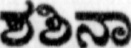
ಶಶಿನಾ
